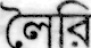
লৈরি
